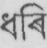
ধৰি
